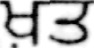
ਖ਼ਤ
